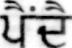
ਪੈਂਦੈ
